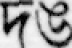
দঙ
